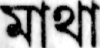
মাথা
